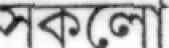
সকলো
